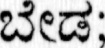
ಬೇಡ;
